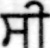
ਸੀ
